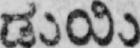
ಡುಯಿ
